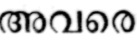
അവരെ
